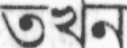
তখন
